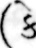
(કે
